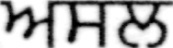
ਅਸਲ
